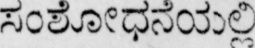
ಸಂಶೋಧನೆಯಲ್ಲಿ
